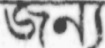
জন্য
